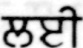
ਲਈ
